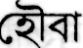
হৌবা
